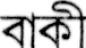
বাকী
